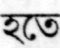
হতে
